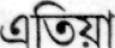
এতিয়া
